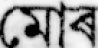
মোৰ
